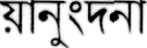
য়ানুংদনা
